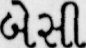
બેસી
